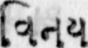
વિનય
